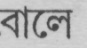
বোলে
